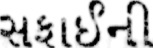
સફાઈની
